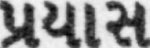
પ્રયાસ
